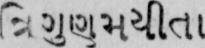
ત્રિગુણમયીતા
